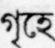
গৃহে
